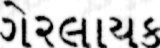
ગેરલાયક
